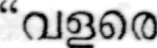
“വളരെ
